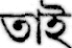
তাই
